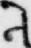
ને
